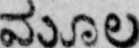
ಮೂಲ
